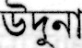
উদুনা
